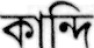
কান্দি
